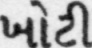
ખોટી
